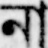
না
